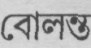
বোলন্ত
